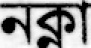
নক্না
